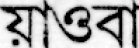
য়াওবা
